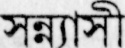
সন্ন্যাসী
